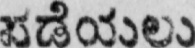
ಪಡೆಯಲು
